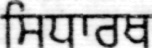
ਸਿਧਾਰਥ
